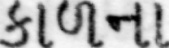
કાળના
